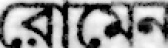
রোমেন
